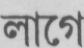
লাগে
